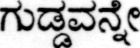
ಗುಡ್ಡವನ್ನೇ
